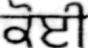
ਕੋਈ
